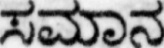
ಸಮಾನ
